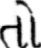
તો
